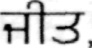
ਜੀਤ,
